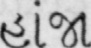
હાંજા
